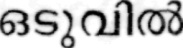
ഒടുവില്‍
